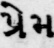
પ્રેમ
